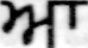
ਆ
